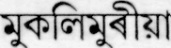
মুকলিমুৰীয়া
